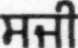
ਸਜੀ
